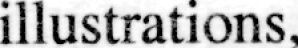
illustrations,
